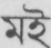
মই
